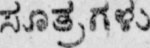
ಸೂತ್ರಗಳು
